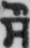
ਸੌ
